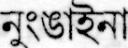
নুংঙাইনা
